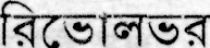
রিভোলভর
